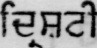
ਦ੍ਰਿਸ਼ਟੀ
